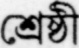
শ্রেষ্ঠী
